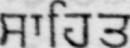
ਸਾਹਿਤ
